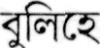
বুলিহে
